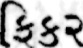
ફિકર
